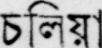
চলিয়া
